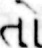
તો
